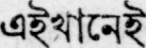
এইখানেই
